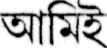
আমিই
